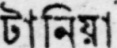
টানিয়া
